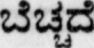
ಬೆಚ್ಚದೆ
